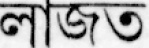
লাজত
